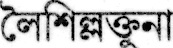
লৈশিল্লক্তুনা
